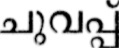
ചുവപ്പ്
